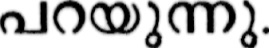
പറയുന്നു.
